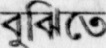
বুঝিতে
